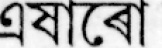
এষাৰো
